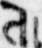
તો
